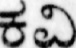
ಕವಿ
